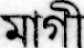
মাগী
